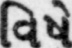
વિષે
